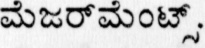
ಮೆಜರ್‌ಮೆಂಟ್ಸ್.
